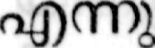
എന്നു
